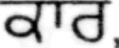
ਕਾਰ,
